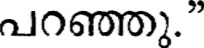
പറഞ്ഞു."
